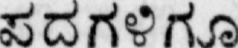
ಪದಗಳಿಗೂ
